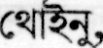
থোইনু,
